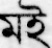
মই
